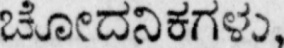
ಚೋದನಿಕಗಳು,
